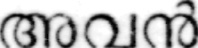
അവന്‍
